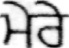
ਮੇਰੇ
